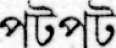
পটপট
